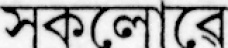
সকলোৱে
